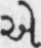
એ
